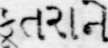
કૂતરાને
